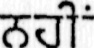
ਨਹੀਂ
